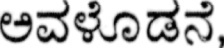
ಅವಳೊಡನೆ,
